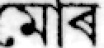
মোৰ
